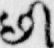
છી
